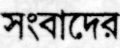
সংবাদের
